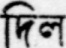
দিল
